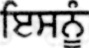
ਇਸਨੂੰ
